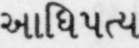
આધિપત્ય
